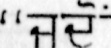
''ਜਦੋਂ
